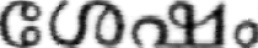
ശേഷം
